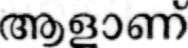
ആളാണ്
